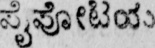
ಪೈಪೋಟಿಯ
